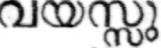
വയസ്സു
